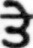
ਤੇ
